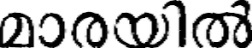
മാരയില്‍
